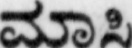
ಮಾಸಿ
